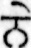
ਨੇ
